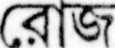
রোজ
